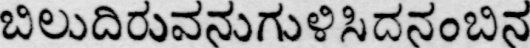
ಬಿಲುದಿರುವನುಗುಳಿಸಿದನಂಬಿನ
